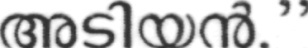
അടിയന്‍."
